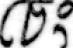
চেং
